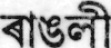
ৰাঙলী
